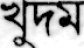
খুদম
